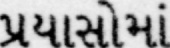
પ્રયાસોમાં
